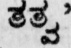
ತತ್ವ’
